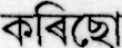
কৰিছো
